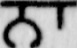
ਨਾ
